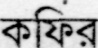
কফির
